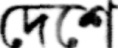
দেশে
